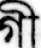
গী
